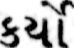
કર્યો
